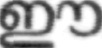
ഈ
